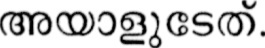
അയാളുടേത്.
